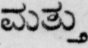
ಮತ್ತು
